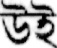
উই
